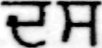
ਦਸ
